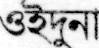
ওইদুনা
